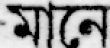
মানে
